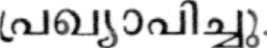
പ്രഖ്യാപിച്ചു.
